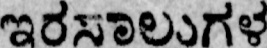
ಇರಸಾಲುಗಳ
